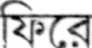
ফিরে
